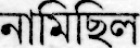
নামিছিল
